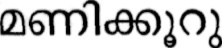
മണിക്കൂറു
